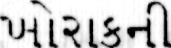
ખોરાકની
